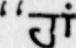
''ਹਾਂ
